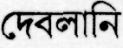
দেবলানি
